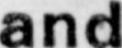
and
